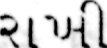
રાખી
